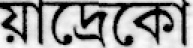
য়াদ্রেকো
